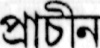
প্রাচীন
